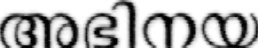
അഭിനയ
